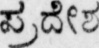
ಪ್ರದೇಶ
